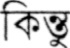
কিন্তু
